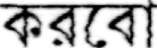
করবো
